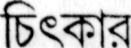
চিৎকার
